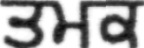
ਤਮਕ
